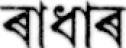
ৰাধাৰ
